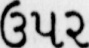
ઉપર
